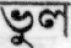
ভুল
